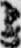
કે
